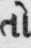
તો
